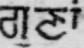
ਗੁਣਾਂ
